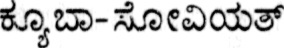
ಕ್ಯೂಬಾ-ಸೋವಿಯತ್
